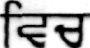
ਵਿਚ
